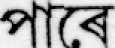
পাৰে
